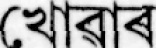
খোৱাৰ
